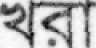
খরা
